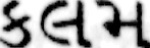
કલમ
